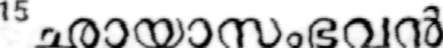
15ഛായാസംഭവന്‍
